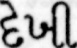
દેખી
